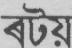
ৰটয়
